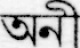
অনী
